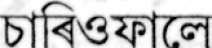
চাৰিওফালে
